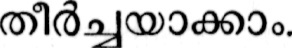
തീര്‍ച്ചയാക്കാം.
